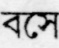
বসে
